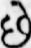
છે
